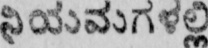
ನಿಯಮಗಳಲ್ಲಿ
